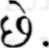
છે.
